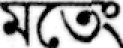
মতেং
